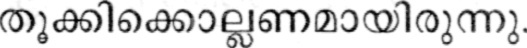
തൂക്കിക്കൊല്ലണമായിരുന്നു.
